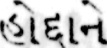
હોદ્દાને
